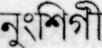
নুংশিগী
